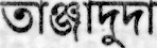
তাঞ্জাদুদা
